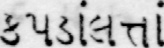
કપડાંલત્તાં
